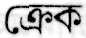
ক্রেক
